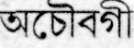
অচৌবগী
